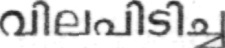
വിലപിടിച്ച
